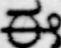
ಈ
